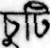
চুটি
